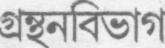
গ্রন্থনবিভাগ
